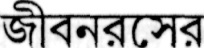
জীবনরসের
